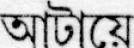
আটায়ে
